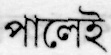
পালেই
